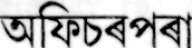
অফিচৰপৰা
